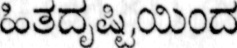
ಹಿತದೃಷ್ಟಿಯಿಂದ
